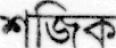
শজিক
